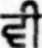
ਵੀ
